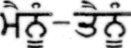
ਮੈਨੂੰ-ਤੈਨੂੰ
